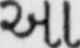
આ
